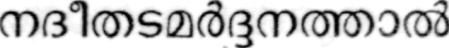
നദീതടമര്‍ദ്ദനത്താല്‍
